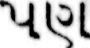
પણ
